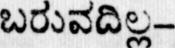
ಬರುವುದಿಲ್ಲ-
